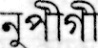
নুপীগী
